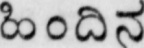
ಹಿಂದಿನ
